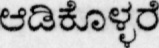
ಆಡಿಕೊಳ್ಳರೆ
